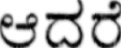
ಆದರೆ
